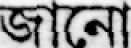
জানো
